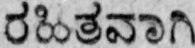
ರಹಿತವಾಗಿ
